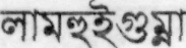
লামহুইগুম্না
